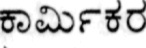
ಕಾರ್ಮಿಕರ
